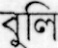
বুলি
